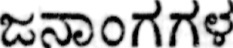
ಜನಾಂಗಗಳ
